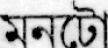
মনটো
